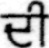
ਦੀ
